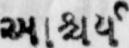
આશ્ચર્ય
